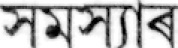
সমস্যাৰ
